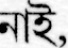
নাই,
